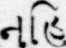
નહિ
